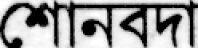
শোনবদা
